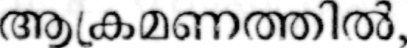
ആക്രമണത്തില്‍,
